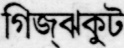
গিজ্ঝকুট
